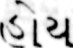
હોય
